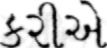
કરીએ
